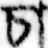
চা
